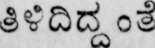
ತಿಳಿದಿದ್ದಂತೆ
